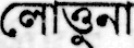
লোত্তুনা
